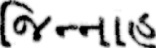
જિન્નાહ
